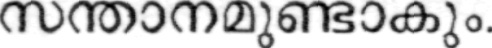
സന്താനമുണ്ടാകും.
